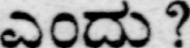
ಎಂದು?
